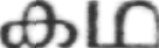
കഥ
